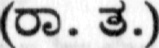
(ರಾ.ತ.)
